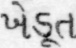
ખેડૂત
